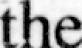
that
